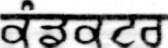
ਕੰਡਕਟਰ
